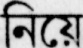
নিয়ে
